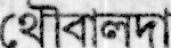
থৌবালদা
